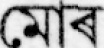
মোৰ
